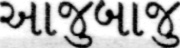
આજુબાજુ
